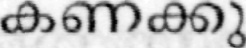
കണക്കു
